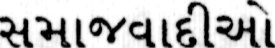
સમાજવાદીઓ
